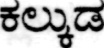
ಕಲ್ಕುಡ
